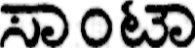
ಸಾಂಟಾ
